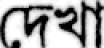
দেখা
